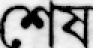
শেষ
